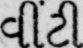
વીંટી
